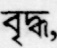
বৃদ্ধ,
